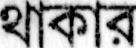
থাকার
